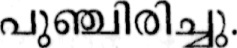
പുഞ്ചിരിച്ചു.
